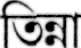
তিন্না
